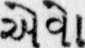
એવો
